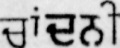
ਚਾਂਦਨੀ
